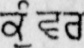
ਕੁੰਵਰ
